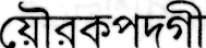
য়ৌরকপদগী
